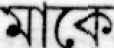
মাকে
